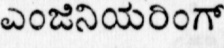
ಎಂಜಿನಿಯರಿಂಗ್
